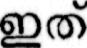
ഇത്
